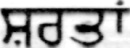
ਸ਼ਰਤਾਂ
